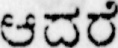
ಆದರೆ
